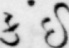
કંઈ
